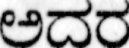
ಅದರ
